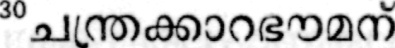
30ചന്ത്രക്കാറഭൌമന്
